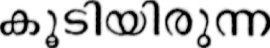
കൂടിയിരുന്ന
